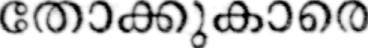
തോക്കുകാരെ
